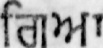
ਗਿਆ
